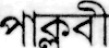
পাক্লবী
